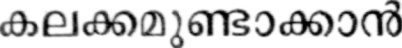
കലക്കമുണ്ടാക്കാന്‍
